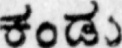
ಕಂಡು
